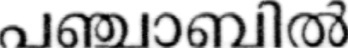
പഞ്ചാബില്‍
